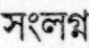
সংলগ্ন
